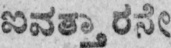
ಐವತ್ತಾರನೇ
